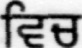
ਵਿਚ
